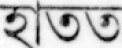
হাতত
